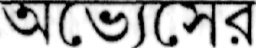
অভ্যেসের
